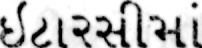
ઇટારસીમાં
